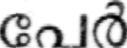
പേര്‍
